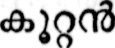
കൂറ്റന്‍
